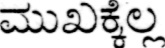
ಮುಖಕ್ಕೆಲ್ಲ
